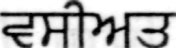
ਵਸੀਅਤ
